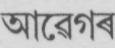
আৱেগৰ
